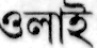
ওলাই
